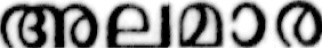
അലമാര
